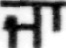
ਜਾ
